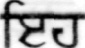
ਇਹ
